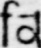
ਕਿ
